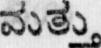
ಮತ್ತು
